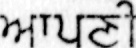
ਆਪਣੀ
